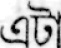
এটা
